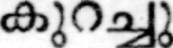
കുറച്ചു
